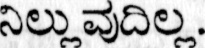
ನಿಲ್ಲುವುದಿಲ್ಲ.
